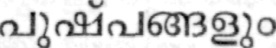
പുഷ്പങ്ങളും
